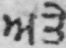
ਅਤੇ
